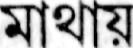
মাথায়
